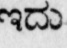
ಇದು
